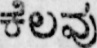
ಕೆಲವು
